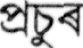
প্রচুৰ
